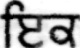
ਇਕ
